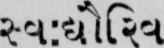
સ્વઃધૌરિવ
